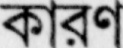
কারণ
